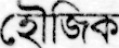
হৌজিক
